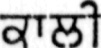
ਕਾਲੀ
